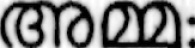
അമ്മ:
